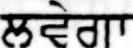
ਲਵੇਗਾ
